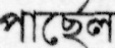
পার্ছেল
